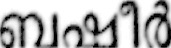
ബഷീര്‍
